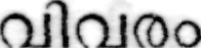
വിവരം
